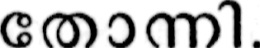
തോന്നി.
